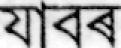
যাবৰ
